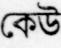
কেউ
